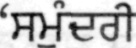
'ਸਮੁੰਦਰੀ
